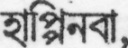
হাপ্পিনবা,
